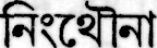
নিংথৌনা
